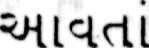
આવતાં
